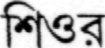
শিওর
